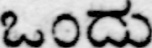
ಒಂದು
